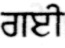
ਗਈ
